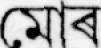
মোৰ
